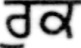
ਰੁਕ
